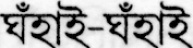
ঘঁহাই-ঘঁহাই
